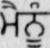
ਮੈਨੂੰ
